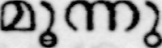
മൂന്നു
